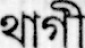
থাগী
